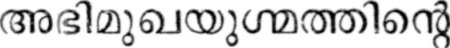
അഭിമുഖയുഗ്മത്തിന്റെ
